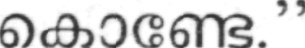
കൊണ്ടേ."
